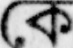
কে
